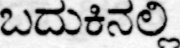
ಬದುಕಿನಲ್ಲಿ
